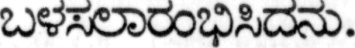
ಬಳಸಲಾರಂಭಿಸಿದನು.
